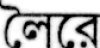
লৈরে
